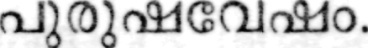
പുരുഷവേഷം.
